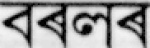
বৰলৰ
